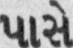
પાસે
